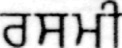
ਰਸਮੀ
